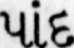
પાંદ
